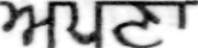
ਅਪਣਾ
